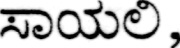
ಸಾಯಲಿ,
